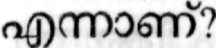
എന്നാണ്?
